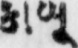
કાબૂ
